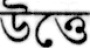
উত্তে
